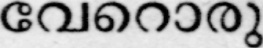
വേറൊരു
